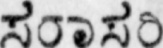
ಸರಾಸರಿ
